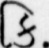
કિ.
